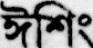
ঈশিং
